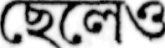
ছেলেও
